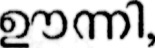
ഊന്നി,
